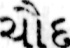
ચૌદ
